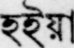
হইয়া
